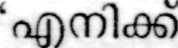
‘എനിക്ക്
